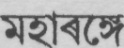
মহাৰঙ্গে
